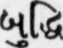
બુદ્ધિ
